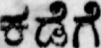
ಕಡೆಗೆ
